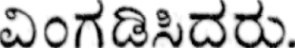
ವಿಂಗಡಿಸಿದರು.
